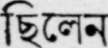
ছিলেন
